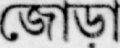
জোড়া
